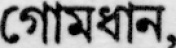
গোমধান,
